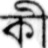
কী
